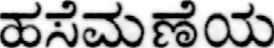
ಹಸೆಮಣೆಯ
